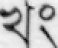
খং
